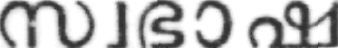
സ്വഭാഷ
